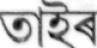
তাইৰ
